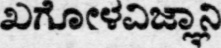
ಖಗೋಳವಿಜ್ಞಾನಿ
